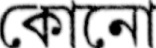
কোনো
